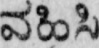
ವಹಿಸಿ
